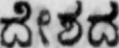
ದೇಶದ
